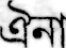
ঐনা
